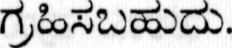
ಗ್ರಹಿಸಬಹುದು.
